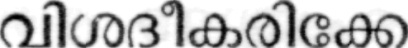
വിശദീകരിക്കേ
